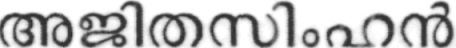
അജിതസിംഹന്‍
